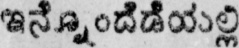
ಇನ್ನೊಂದೆಡೆಯಲ್ಲಿ
